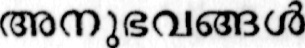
അനുഭവങ്ങള്‍
